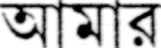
আমার
